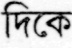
দিকে
